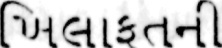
ખિલાફતની
